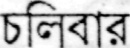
চলিবার
